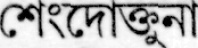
শেংদোক্তুনা
